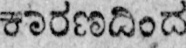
ಕಾರಣದಿಂದ
